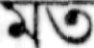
মত
